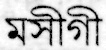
মসীগী
